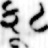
ફૂટ
